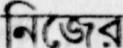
নিজের
